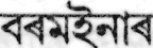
বৰমইনাৰ
